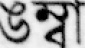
ঙম্বা
